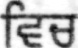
ਵਿਚ
